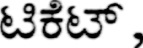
ಟಿಕೆಟ್,
